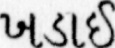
ખડાઈ
